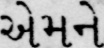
એમને
